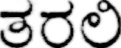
ತರಲಿ
